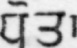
ਧੋਤਾ
